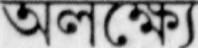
অলক্ষ্যে
